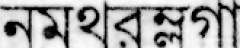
নমথরম্লগা
